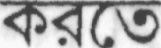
করতে
